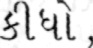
કીધો,
